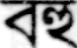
বহু
